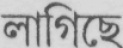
লাগিছে
